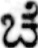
ಚೆ
